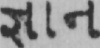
જ્ઞાન
